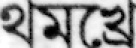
থমখ্রে
